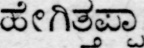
ಹೇಗಿತ್ತಪ್ಪಾ
